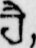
ਹੈ,
